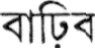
বাঢ়িব
